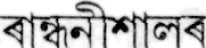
ৰান্ধনীশালৰ
